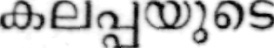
കലപ്പയുടെ
